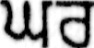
ਘਰ
